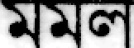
মমল
